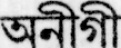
অনীগী
